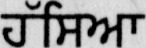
ਹੱਸਿਆ
